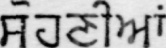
ਸੋਹਣੀਆਂ
